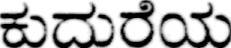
ಕುದುರೆಯ
